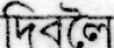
দিবলৈ
